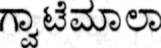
ಗ್ವಾಟೆಮಾಲಾ
